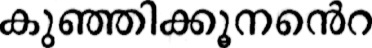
കുഞ്ഞിക്കൂനന്റെ
